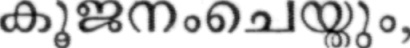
കൂജനംചെയ്തും,
